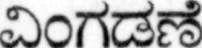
ವಿಂಗಡಣೆ
